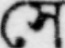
সে
